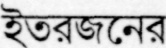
ইতরজনের
